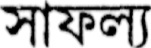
সাফল্য
